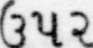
ઉપર
